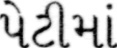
પેટીમાં
